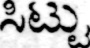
ಸಿಟ್ಟು
